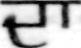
ਦਾ
